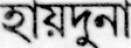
হায়দুনা
